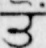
ਤੋਂ
